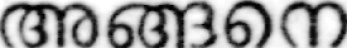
അങ്ങനെ
